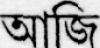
আজি
